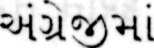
અંગ્રેજીમાં
